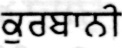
ਕੁਰਬਾਨੀ
